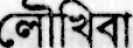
লৌখিবা
